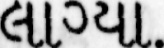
લાગ્યા.
